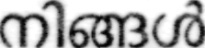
നിങ്ങള്‍
